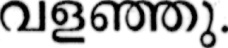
വളഞ്ഞു.
